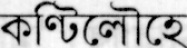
কণ্টিলৌহে
